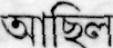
আছিল
